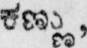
ಕಣ್ಣು,
